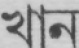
খান
